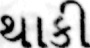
થાકી
